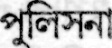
পুলিসনা
